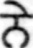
ਨੇ
